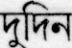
দুদিন
